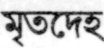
মৃতদেহ
